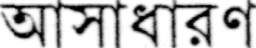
আসাধারণ
